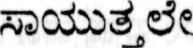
ಸಾಯುತ್ತಲೇ
